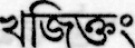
খজিক্তং
